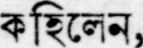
কহিলেন,
